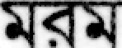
মরম
